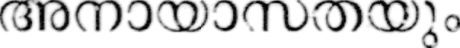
അനായാസതയും
